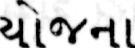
યોજના
